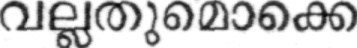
വല്ലതുമൊക്കെ
